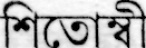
শিতোম্বী
